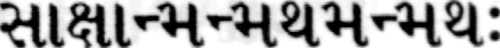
સાક્ષાન્મન્મથમન્મથઃ
